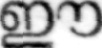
ഈ
